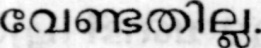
വേണ്ടതില്ല.
